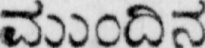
ಮುಂದಿನ
